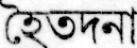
হৈতদনা
